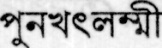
পুনখৎলম্মী
